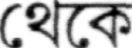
থেকে
